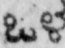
ಒಳ
